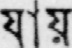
যায়
